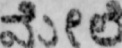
ಮೇಲೆ
